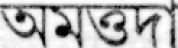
অমত্তদা
